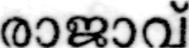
രാജാവ്
